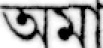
অমা
